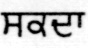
ਸਕਦਾ
